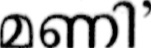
മണി'
